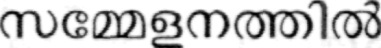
സമ്മേളനത്തില്‍
